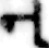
ન
